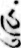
હું
